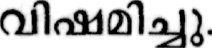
വിഷമിച്ചു.
